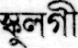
স্কুলগী
